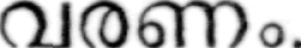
വരണം.
